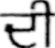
ਦੀ
